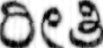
ರೀತಿ
